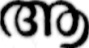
ആ
